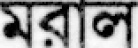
মরাল
